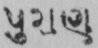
પુરાણ
